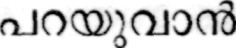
പറയുവാന്‍
